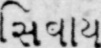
સિવાય
